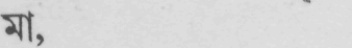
মা,
